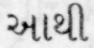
આથી
